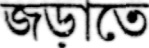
জড়াতে
